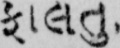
ફાલતુ.
